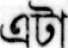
এটা
